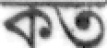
কত
